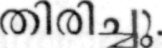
തിരിച്ചു.
